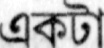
একটা
